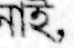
নাই,
